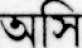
অসি
